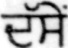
ਦੱਸੇਂ
